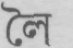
লৈ
